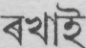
ৰখাই
